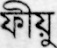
ফীয়ু
